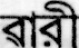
ৱারী
